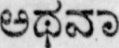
ಅಥವಾ
